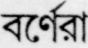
বর্ণেরা
